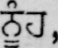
ਨੂੰਹ,
